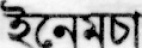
ইনেমচা
